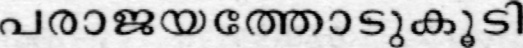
പരാജയത്തോടുകൂടി
